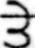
ਤੇ
